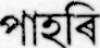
পাহৰি
